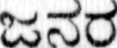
ಜನರ
